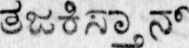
ತಜಕಿಸ್ತಾನ್
